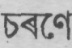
চৰণে
